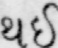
થઈ
